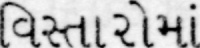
વિસ્તારોમાં
